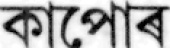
কাপোৰ
